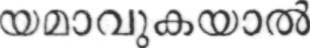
യമാവുകയാല്‍
